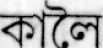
কালৈ
